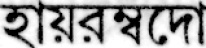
হায়রম্বদো
